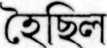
হৈছিল
